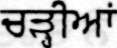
ਚੜ੍ਹੀਆਂ
